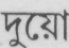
দুয়ো
